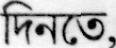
দিনতে,
